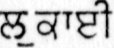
ਲੁਕਾਈ
